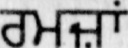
ਰਮਜ਼ਾਂ
